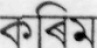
কৰিম
